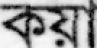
কয়া
